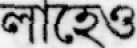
লাহেও
